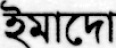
ইমাদো
